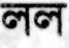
লল
